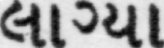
લાગ્યા
